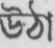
উঠা
